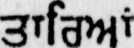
ਤਾਰਿਆਂ
